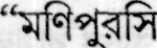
“মণিপুরসি
